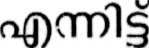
എന്നിട്ട്
